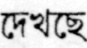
দেখছে
